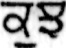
ਕੁਝ
